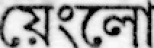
য়েংলো
